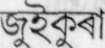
জুইকুৰা
